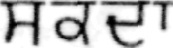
ਸਕਦਾ
